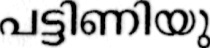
പട്ടിണിയു
